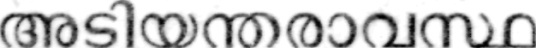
അടിയന്തരാവസ്ഥ
